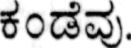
ಕಂಡೆವು.
